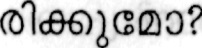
രിക്കുമോ?
